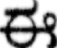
ಈ
